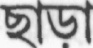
ছাড়া
